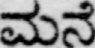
ಮನೆ
